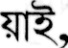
য়াই,
